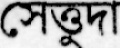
সেত্তুদা
